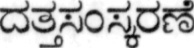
ದತ್ತಸಂಸ್ಕರಣೆ
